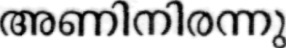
അണിനിരന്നു
